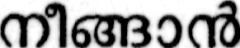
നീങ്ങാന്‍
